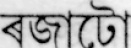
ৰজাটো
